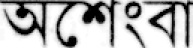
অশেংবা
